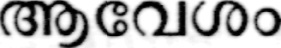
ആവേശം
